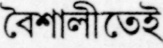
বৈশালীতেই
